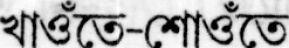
খাওঁতে-শোওঁতে
